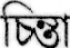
চিন্তা
